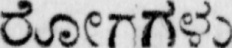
ರೋಗಗಳು
